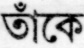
তাঁকে
